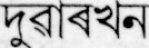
দুৱাৰখন
